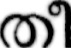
തീ
